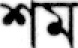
শম
